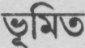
ভূমিত
